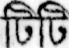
টিটি
